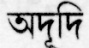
অদূদি
